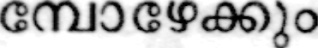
മ്പോഴേക്കും
